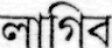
লাগিব
